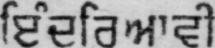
ਇੰਦਰਿਆਵੀ
